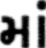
માં
